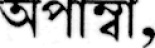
অপাম্বা,
